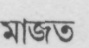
মাজত
